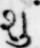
શું
